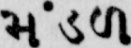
મંડળ
